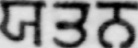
ਯਤਨ
